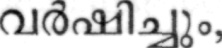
വര്‍ഷിച്ചും,
